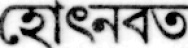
হোৎনবত
